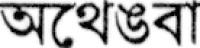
অথেঙবা
